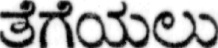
ತೆಗೆಯಲು
